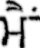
ਮੈਂ
